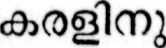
കരളിനു
